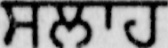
ਸਲਾਹ
